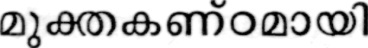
മുക്തകണ്ഠമായി
